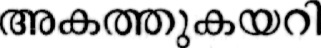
അകത്തുകയറി
